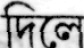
দিলে
